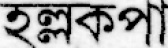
হল্লকপা
